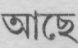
আছে
